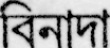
বিনাদা
